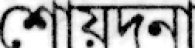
শোয়দনা
